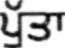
ਪੁੱਤਾ
